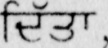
ਦਿੱਤਾ,
